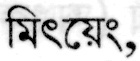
মিৎয়েং,
